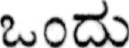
ಒಂದು
